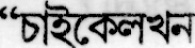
"চাইকেলখন
